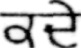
ਕਦੇ
